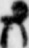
ಗೆ
